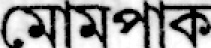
মোমপাক
